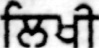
ਲਿਖੀ
